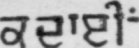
ਕਦਾਈਂ
